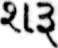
શરૂ
